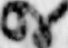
જ
